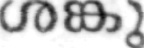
ശങ്കു
